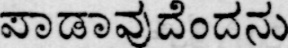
ಪಾಡಾವುದೆಂದನು
